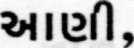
આણી,
